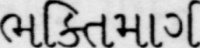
ભક્તિમાર્ગ
